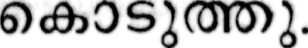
കൊടുത്തു.
